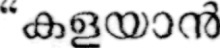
"കളയാന്‍
